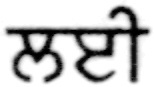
ਲਈ
